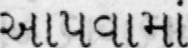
આપવામાં
